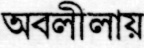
অবলীলায়
